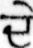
ਦੇ
